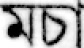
মচা
